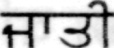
ਜਾਤੀ
